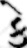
કે
